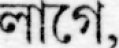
লাগে,
